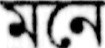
মনে
